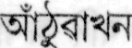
আঁঠুৱাখন
